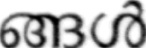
ങ്ങള്‍
